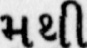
મથી
